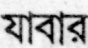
যাবার
